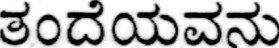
ತಂದೆಯವನು
